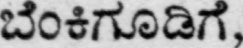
ಬೆಂಕಿಗೂಡಿಗೆ,
